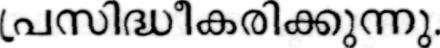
പ്രസിദ്ധീകരിക്കുന്നു.
